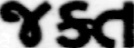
જક્ત
